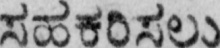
ಸಹಕರಿಸಲು
